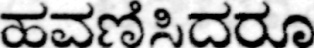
ಹವಣಿಸಿದರೂ
